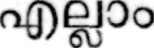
എല്ലാം
